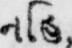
નહિ,
